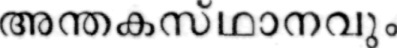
അന്തകസ്ഥാനവും
